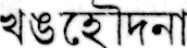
খঙহৌদনা
